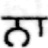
ਨਾ
